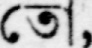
তো,
